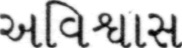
અવિશ્વાસ
